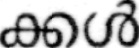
ക്കള്‍
